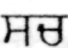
ਸਚ
